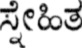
ಸ್ನೇಹಿತ
